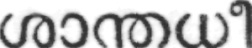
ശാന്തധീ
